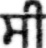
ਸੀ
